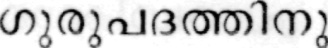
ഗുരുപദത്തിനു
